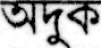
অদুক
